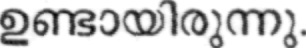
ഉണ്ടായിരുന്നു.
